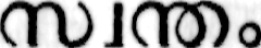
സ്വന്തം
